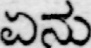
ಏನು
